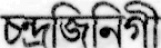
চন্দ্রজিনিগী
